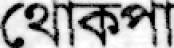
থোকপা
